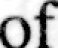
of
